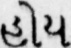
હોય
